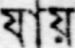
যায়
